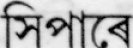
সিপাৰে
